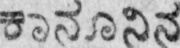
ಕಾನೂನಿನ
